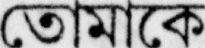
তোমাকে
